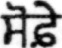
ਸੋਫ਼ੇ
